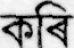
কৰি
